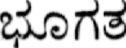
ಭೂಗತ
